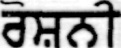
ਰੋਸ਼ਨੀ
